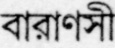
বারাণসী
